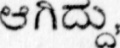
ಆಗಿದ್ದು,
